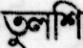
তুলশি
